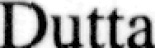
Dutta
